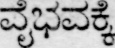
ವೈಭವಕ್ಕೆ
